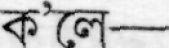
ক'লে-
